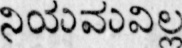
ನಿಯಮವಿಲ್ಲ
